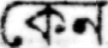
কেন
